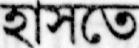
হাসতে
